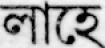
লাহে
